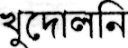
খুদোলনি
